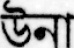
উনা
